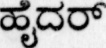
ಹೈದರ್
